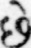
છે
